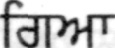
ਗਿਆ
